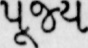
પૂજ્ય
